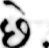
છે.
